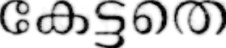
കേട്ടതെ
